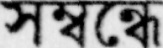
সম্বন্ধে
